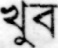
খুব
